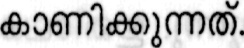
കാണിക്കുന്നത്.
